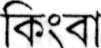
কিংবা
